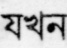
যখন
